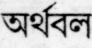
অর্থবল
